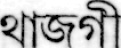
থাজগী
